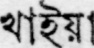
খাইয়া
